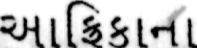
આફ્રિકાના
